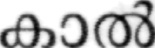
കാല്‍
